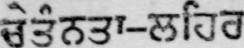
ਚੇਤੰਨਤਾ-ਲਹਿਰ
